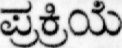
ಪ್ರಕ್ರಿಯೆ
